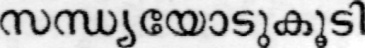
സന്ധ്യയോടുകൂടി
